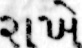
રાખે
